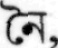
নৈ,
